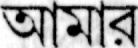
আমার
